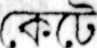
কেটে
